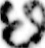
છ
